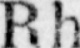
Rh
